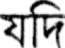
যদি
